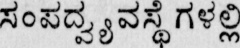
ಸಂಪದ್ವ್ಯವಸ್ಥೆಗಳಲ್ಲಿ
